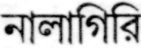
নালাগিরি
